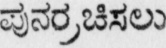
ಪುನರ್ರಚಿಸಲು
